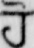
ਹੋ
